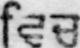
ਵਿਚ
